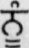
ਨੂੰ
